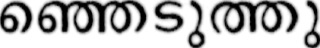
ഞ്ഞെടുത്തു
